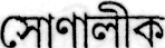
সোণালীক
